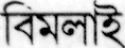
বিমলাই
